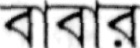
বাবার
